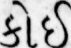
કોઈ
